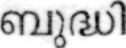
ബുദ്ധി
